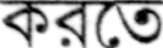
করতে
